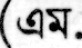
(এম.
